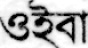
ওইবা
